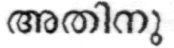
അതിനു
